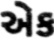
એક
